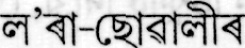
ল'ৰা-ছোৱালীৰ
